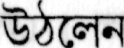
উঠলেন
